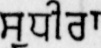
ਸੁਧੀਰਾ
